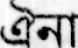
ঐনা
